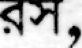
রস,
